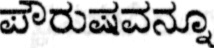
ಪೌರುಷವನ್ನೂ
